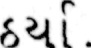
ઠર્યા.
